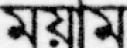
ময়াম
